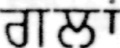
ਗਲਾਂ
